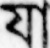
যা
